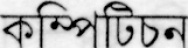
কম্পিটিচন
